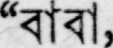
‘‘বাবা,
